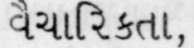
વૈચારિકતા,
